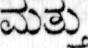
ಮತ್ತು
